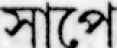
সাপে
